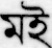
মই
